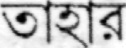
তাহার
